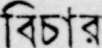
বিচার
